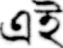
এই
